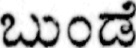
ಬುಂಡೆ
